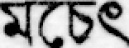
মচেৎ
